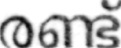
രണ്ട്
